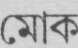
মোক
